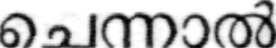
ചെന്നാല്‍
